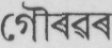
গৌৰৱৰ
